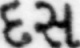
દસ
